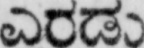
ಎರಡು
